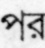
পর
